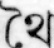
থৈ
